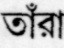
তাঁরা
